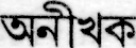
অনীখক
